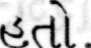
હતો.
